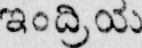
ಇಂದ್ರಿಯ
